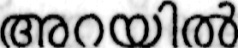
അറയില്‍
